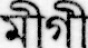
মীগী
